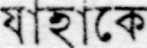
যাহাকে
